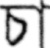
চা
